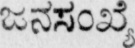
ಜನಸಂಖ್ಯೆ
